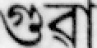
গুৱা
